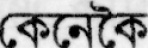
কেনেকৈ
